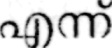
എന്ന്
